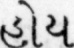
હોય
